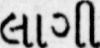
લાગી
